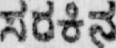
ಸರಕಿನ
